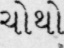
ચોથો
